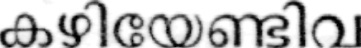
കഴിയേണ്ടിവ
